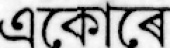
একোৰে
